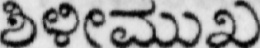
ಶಿಳೀಮುಖ
